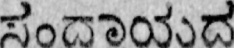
ಸಂದಾಯದ
